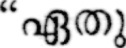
“ഏതു
